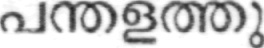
പന്തളത്തു
